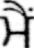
ਮੈਂ
